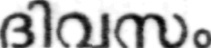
ദിവസം
